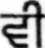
ਵੀ
